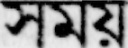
সময়
